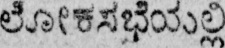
ಲೋಕಸಭೆಯಲ್ಲಿ
